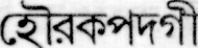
হৌরকপদগী
